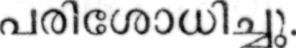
പരിശോധിച്ചു.
